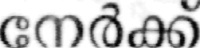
നേര്‍ക്ക്
